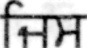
ਜਿਸ
